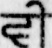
ਵੀ
